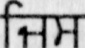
ਜਿਸ
